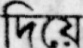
দিয়ে
